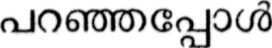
പറഞ്ഞപ്പോള്‍
